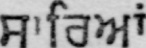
ਸਾਰਿਆਂ
